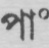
পা
